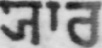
ਯਾਰ
